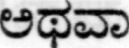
ಅಥವಾ
